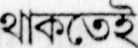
থাকতেই
